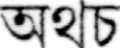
অথচ
